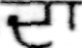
ਦਾ
